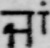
ਜਾਂ
